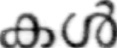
കള്‍
